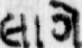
લાગે
